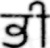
ਭੀ
